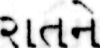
રાતને
